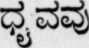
ಧೃವವು
